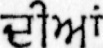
ਦੀਆਂ
